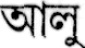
আলু
